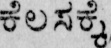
ಕೆಲಸಕ್ಕೆ
